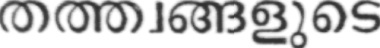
തത്ത്വങ്ങളുടെ
